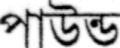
পাউন্ড
